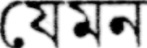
যেমন
